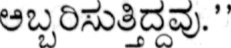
ಅಬ್ಬರಿಸುತ್ತಿದ್ದವು."
